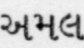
અમલ
